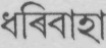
ধৰিবাহা
